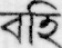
বহি
